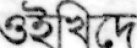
ওইখিদে
